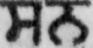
ਸਨ
